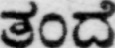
ತಂದೆ
